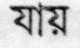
যায়
